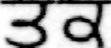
ਤਕ
